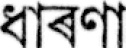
ধাৰণা
